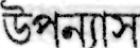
উপন্যাস
